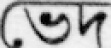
ভেদ
